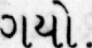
ગયો.
